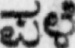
ಪಳೆ
